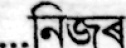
...নিজৰ
